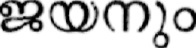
ജയനും
